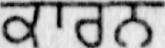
ਕਾਰਨ
